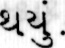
થયું.
